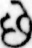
છે
